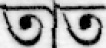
তাত
